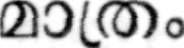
മാത്രം
